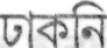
ঢাকনি
